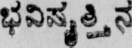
ಭವಿಷ್ಯತ್ತಿನ
